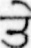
ਤੇ
